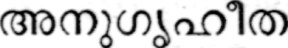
അനുഗൃഹീത
